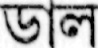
ডাল
